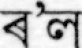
ৰ'ল
